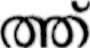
ത്ത്
